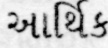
આર્થિક
